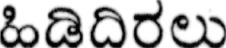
ಹಿಡಿದಿರಲು
